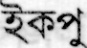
ইকপু
